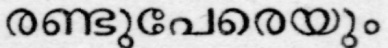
രണ്ടുപേരെയും
